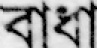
বাধা
